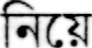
নিয়ে
